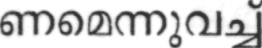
ണമെന്നുവച്ച്
